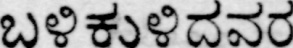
ಬಳಿಕುಳಿದವರ
